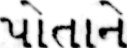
પોતાને
